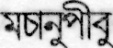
মচানুপীবু
